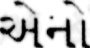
એનો
